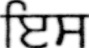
ਇਸ
